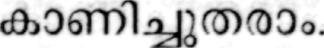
കാണിച്ചുതരാം.
